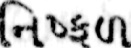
નિષ્ફળ
